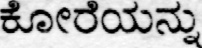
ಕೋರೆಯನ್ನು
